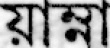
য়ম্না
